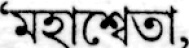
'মহাশ্বেতা,
